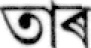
তাৰ
